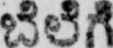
ಬೆಲೆಗೆ
